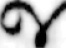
જ
